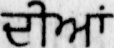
ਦੀਆਂ
